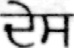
ਦੇਸ
